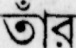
তাঁর
